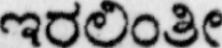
ಇರಲಿಂತೀ
